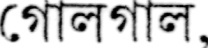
গোলগাল,
